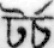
টর্চ
